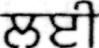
ਲਈ
